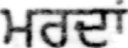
ਮਰਦਾਂ
